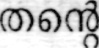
തന്റെ
